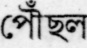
পৌঁছল
